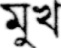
মুখ
